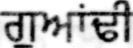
ਗੁਆਂਢੀ
